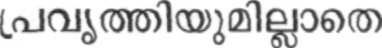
പ്രവൃത്തിയുമില്ലാതെ
